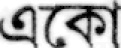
একো
